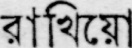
রাখিয়ো
